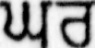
ਘਰ
